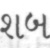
શબ
